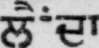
ਲੈਂਦਾ
